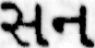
સન
